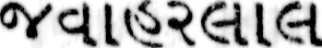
જવાહરલાલ
